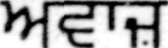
ਅਵਾਜ਼
